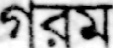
গরম
